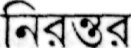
নিরন্তর
